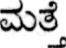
ಮತ್ತೆ
